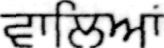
ਵਾਲਿਆਂ
